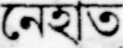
নেহাত
